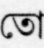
তো
